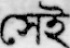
সেই
